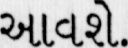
આવશે.
